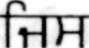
ਜਿਸ
